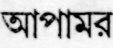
আপামর
